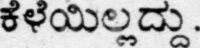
ಕೆಳೆಯಿಲ್ಲದ್ದು.
